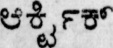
ಆರ್ಕ್ಟಿಕ್
